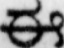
ಈ
